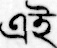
এই
